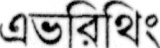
এভরিথিং
